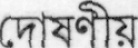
দোষণীয়
